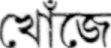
খোঁজে
